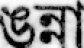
ঙন্না
